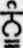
ਨੂੰ
